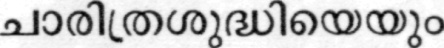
ചാരിത്രശുദ്ധിയെയും
